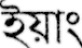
ইয়াং
